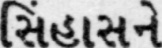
સિંહાસને
